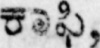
ಕಾಫಿ,
